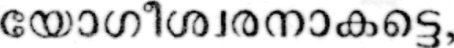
യോഗീശ്വരനാകട്ടെ,
